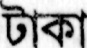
টাকা
